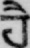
ਹੈ
